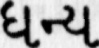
ધન્ય
